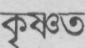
কৃষ্ণত
